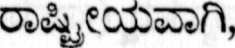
ರಾಷ್ಟ್ರೀಯವಾಗಿ,
